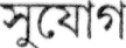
সুযোগ
